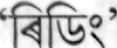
'ৰিডিং'
